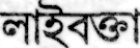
লাইবক্তা
